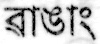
ৱাঙাং
